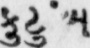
કુટુંબ
